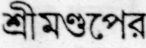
শ্রীমণ্ডপের
